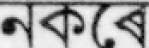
নকৰে
